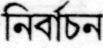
নির্বাচন
